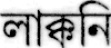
লাক্কনি
